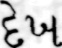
દેખ
